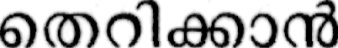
തെറിക്കാന്‍
